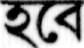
হবে
